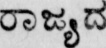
ರಾಜ್ಯದ
